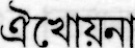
ঐখোয়না
